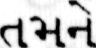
તમને
